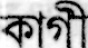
কাগী
